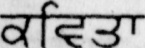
ਕਵਿਤਾ
